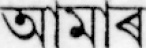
আমাৰ
